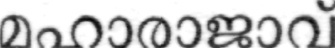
മഹാരാജാവ്
